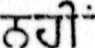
ਨਹੀਂ
